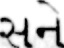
સને
